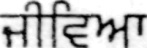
ਜੀਵਿਆ
